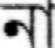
না
